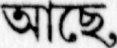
আছে,
